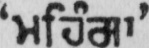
'ਮਹਿੰਗਾ'
